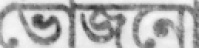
ভোজনো
